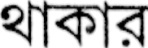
থাকার
